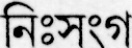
নিঃসংগ
